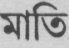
মাতি
